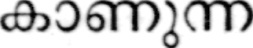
കാണുന്ന
